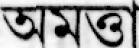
অমত্তা
